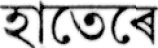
হাতেৰে
